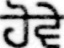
ਹੋਵੇ
